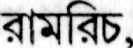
রামরিচ,
